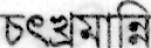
চৎখ্রমান্নি
